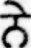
ਨੇ
